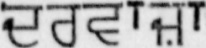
ਦਰਵਾਜ਼ਾ
